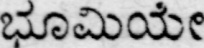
ಭೂಮಿಯೇ
